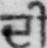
ਦੀ
